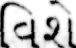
વિશે
